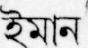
ইমান
